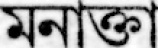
মনাক্তা
